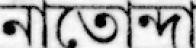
নাতোন্দা
